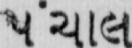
પંચાલ
